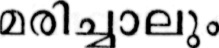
മരിച്ചാലും
